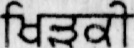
ਖਿੜਕੀ
